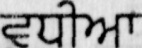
ਵਧੀਆ
